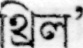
থ্রিল'
